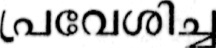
പ്രവേശിച്ച
